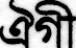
ঐগী
